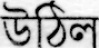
উঠিল
